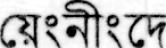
য়েংনীংদে
